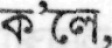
ক'লে,
